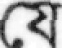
যে
